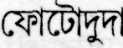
ফোটোদুদা
